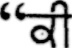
''ਕੀ
